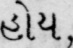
હોય,
